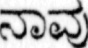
ನಾವು
